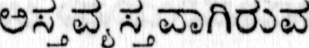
ಅಸ್ತವ್ಯಸ್ತವಾಗಿರುವ
